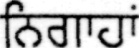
ਨਿਗਾਹਾਂ
